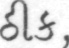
ઠીક,
